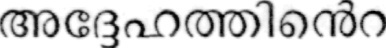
അദ്ദേഹത്തിന്റെ
